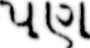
પણ
